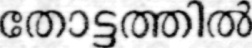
തോട്ടത്തില്‍
